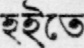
হইতে
